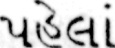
પહેલાં
